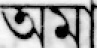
অমা
